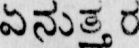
ಏನುತ್ತರ
